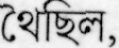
থৈছিল,
